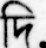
দি.
